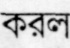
করল
